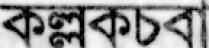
কল্লকচবা
